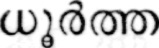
ധൂര്‍ത്ത
